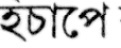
হিচাপে
